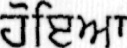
ਹੋਇਆ
